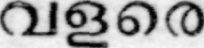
വളരെ
